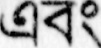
এবং
